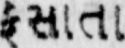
ફસાતા
